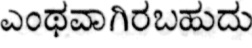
ಎಂಥವಾಗಿರಬಹುದು
